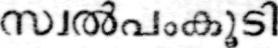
സ്വല്‍പംകൂടി
